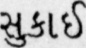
સુકાઈ
